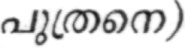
പുത്രനെ)
